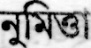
নুমিত্তা
